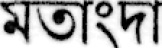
মতাংদা
